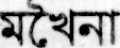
মখৈনা
